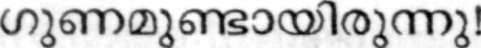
ഗുണമുണ്ടായിരുന്നു!
